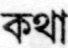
কথা
